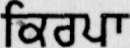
ਕਿਰਪਾ
